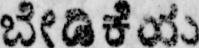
ಬೇಡಿಕೆಯ
